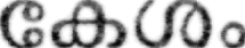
കേശം
